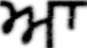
ਆ
